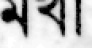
মখা
